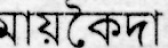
মায়কৈদা
